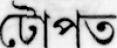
টোপত
